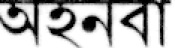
অহনবা
